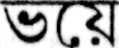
ভয়ে
